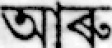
আৰু
